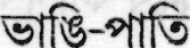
ভাঙি-পাতি
